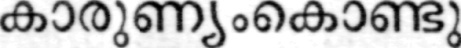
കാരുണ്യംകൊണ്ടു
